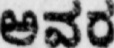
ಅವರ
